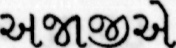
અજાજીએ
